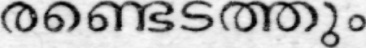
രണ്ടെടത്തും
